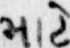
માટે
